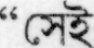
"সেই
